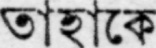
তাহাকে
